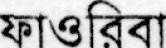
ফাওরিবা
